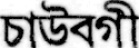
চাউবগী
